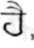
ਹੈ,
